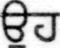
ਉਹ
